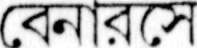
বেনারসে
